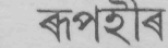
ৰূপহীৰ
